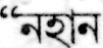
“নহান
